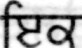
ਇਕ
